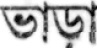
ভাড়া
